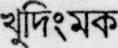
খুদিংমক
